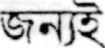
জন্যই
